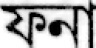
ফনা
